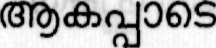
ആകപ്പാടെ
